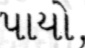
પાયો,
